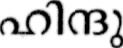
ഹിന്ദു
